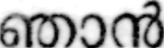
ഞാന്‍
